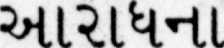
આરાધના
